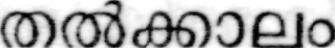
തല്‍ക്കാലം
